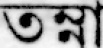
তম্না
